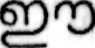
ഈ
